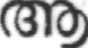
ആ
